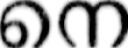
നെ
